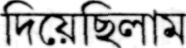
দিয়েছিলাম
